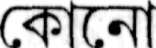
কোনো
